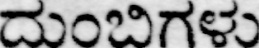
ದುಂಬಿಗಳು
